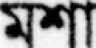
মশা
